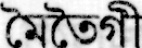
মৈতৈগী
